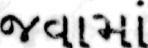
જવામાં
